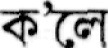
ক'লে
